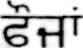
ਫੌਜਾਂ
